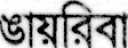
ঙায়রিবা
